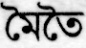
মৈতৈ
